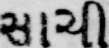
સાચી
